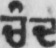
ਚੰਦ
